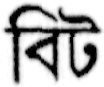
বিট
